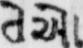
તેઓ
